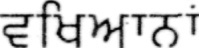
ਵਖਿਆਨਾਂ
